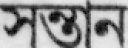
সন্তান
